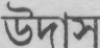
উদাস
